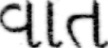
વાત
